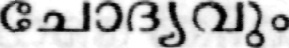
ചോദ്യവും
